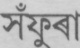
সঁফুৰা
